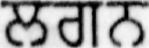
ਲਗਨ
